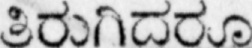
ತಿರುಗಿದರೂ
